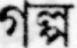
গল্প
